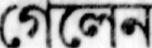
গেলেন
